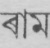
ৰাম
